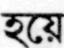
হয়ে
